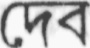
দেব
